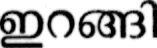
ഇറങ്ങി
